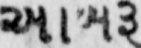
આબરૂ
